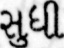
સુધી
